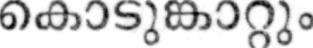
കൊടുങ്കാറ്റും
